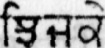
ਝਿਜਕੇ
